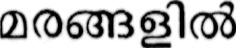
മരങ്ങളില്‍
